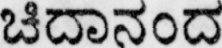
ಚಿದಾನಂದ
